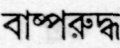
বাষ্পরুদ্ধ
